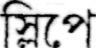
স্লিপে
